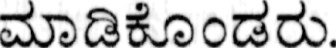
ಮಾಡಿಕೊಂಡರು.
